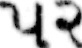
પર
